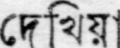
দেখিয়া
